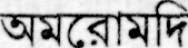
অমরোমদি
